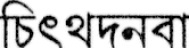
চিৎথদনবা
